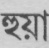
হুয়া
